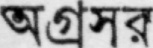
অগ্রসর
